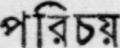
পরিচয়
